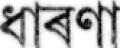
ধাৰণা
